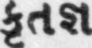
કૃતજ્ઞ
